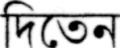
দিতেন
